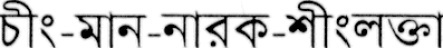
চীং-মান-নারক-শীংলক্তা
